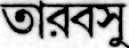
তারবসু
